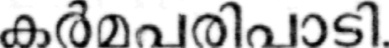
കര്‍മപരിപാടി.
